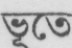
ভূতে
